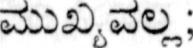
ಮುಖ್ಯವಲ್ಲ;
